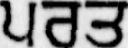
ਪਰਤ
